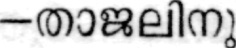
-താജലിനു
